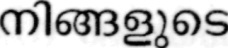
നിങ്ങളുടെ
